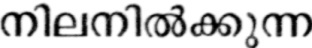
നിലനില്‍ക്കുന്ന
